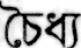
চৈধ্য
